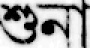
শুনা
